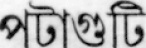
পটাগুটি
